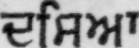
ਦਸਿਆ
